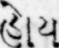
હોય
